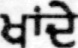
ਖਾਂਦੇ
